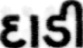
દાડી
